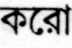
করো
